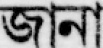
জানা
